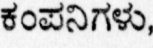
ಕಂಪನಿಗಳು,
